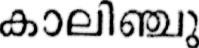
കാലിഞ്ചു
